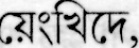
য়েংখিদে,
